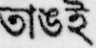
তাঙই
